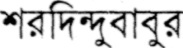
শরদিন্দুবাবুর
